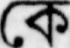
কে
